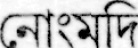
নোংমদি
